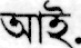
আই.
